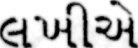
લખીએ
